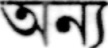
অন্য
